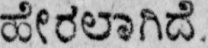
ಹೇರಲಾಗಿದೆ.
